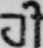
ਹੀ
